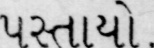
પસ્તાયો.
